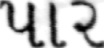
પાર
